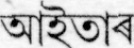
আইতাৰ
